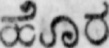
ಹೊರ
